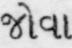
જોવા
